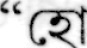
“হো
